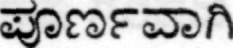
ಪೂರ್ಣವಾಗಿ
